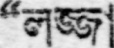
‘‘লজ্জা
